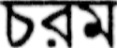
চরম
